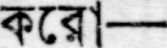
করো—
